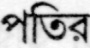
পতির
